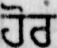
ਹੋਰ
